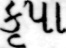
કૃપા
